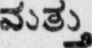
ಮತ್ತು
